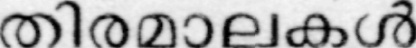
തിരമാലകള്‍
